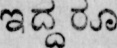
ಇದ್ದರೂ
